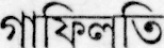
গাফিলতি
